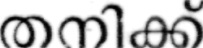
തനിക്ക്
